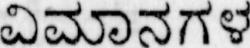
ವಿಮಾನಗಳ
